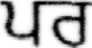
ਪਰ
